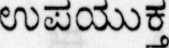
ಉಪಯುಕ್ತ
